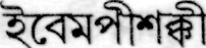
ইবেমপীশক্কী
